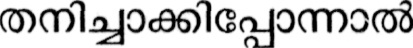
തനിച്ചാക്കിപ്പോന്നാല്‍
